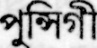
পুন্সিগী
